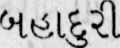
બહાદુરી
